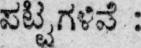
ಪಟ್ಟಿಗಳಿವೆ:
